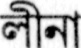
লীনা
